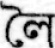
লৈ
